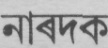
নাৰদক
